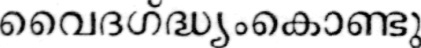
വൈദഗ്ദ്ധ്യംകൊണ്ടു
